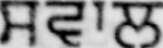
ਸਵਾਲ
